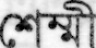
শেম্মী
